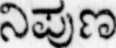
ನಿಪುಣ
